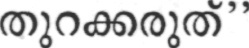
തുറക്കരുത്"
